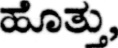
ಹೊತ್ತು,
